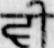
ਵੀ
